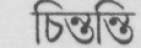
চিন্তন্তি
